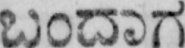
ಬಂದಾಗ
